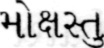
મોક્ષસ્તુ
